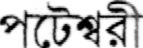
পটেশ্বরী
